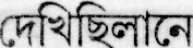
দেখিছিলানে
